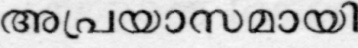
അപ്രയാസമായി
